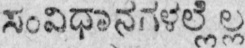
ಸಂವಿಧಾನಗಳಲ್ಲೆಲ್ಲ
